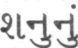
શનુનું
